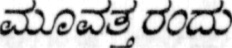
ಮೂವತ್ತರಂದು
